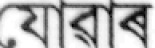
যোৱাৰ
